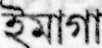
ইমাগা
